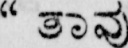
“ತಾವು
